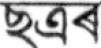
ছত্রৰ
